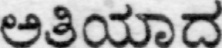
ಅತಿಯಾದ
